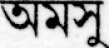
অমসু
